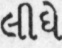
લીધે
